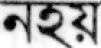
নহয়
